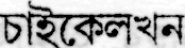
চাইকেলখন
